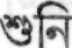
শুনি
